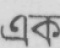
এক
